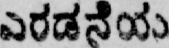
ಎರಡನೆಯ
